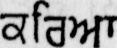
ਕਰਿਆ
